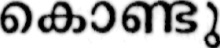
കൊണ്ടു
